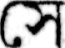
সে
